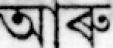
আৰু
